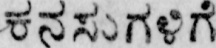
ಕನಸುಗಳಿಗೆ
